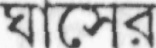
ঘাসের
